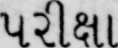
પરીક્ષા
